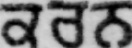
ਕਰਨ
